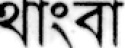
থাংবা
